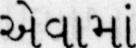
એવામાં
